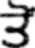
ਤੋਂ
